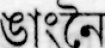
ঙাংনৈ
